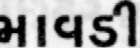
માવડી
